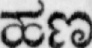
ಹಣ
